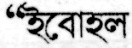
“ইবোহল
